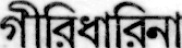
গীরিধারিনা
